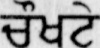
ਚੌਖਟੇ
